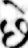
છે
